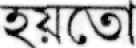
হয়তো
